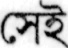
সেই
